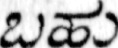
ಬಹು
